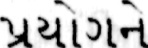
પ્રયોગને
